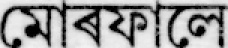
মোৰফালে
